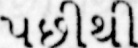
પછીથી
